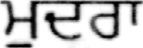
ਮੁਦਰਾ
